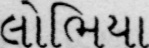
લોભિયા
